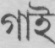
গাই
